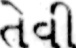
તેવી
